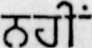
ਨਹੀਂ
